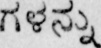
ಗಳನ್ನು
